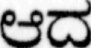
ಆದ
